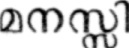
മനസ്സി
